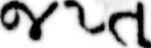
જપ્ત
